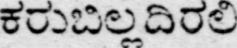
ಕರುಬಿಲ್ಲದಿರಲಿ
